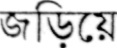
জড়িয়ে
